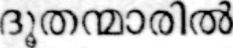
ദൂതന്മാരില്‍
